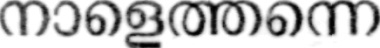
നാളെത്തന്നെ
